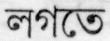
লগতে
